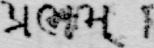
પ્રભમ્
